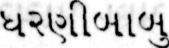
ધરણીબાબુ
